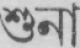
শুনা
